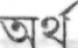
অর্থ
